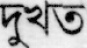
দুখত
